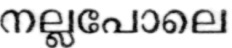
നല്ലപോലെ
